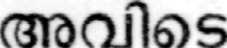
അവിടെ
